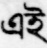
এই
